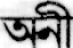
অনী
